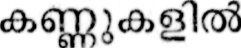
കണ്ണുകളില്‍
